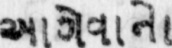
આગેવાનો
